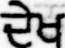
ਦੇਖ
